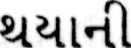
થયાની
